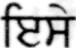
ਇਸੇ
